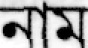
নাম
